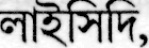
লাইসিদি,
